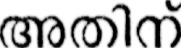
അതിന്
